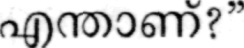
എന്താണ്?"
